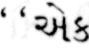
"એક
